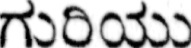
ಗುರಿಯು
